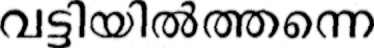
വട്ടിയില്‍ത്തന്നെ
